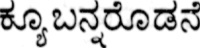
ಕ್ಯೂಬನ್ನರೊಡನೆ
